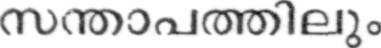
സന്താപത്തിലും
